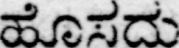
ಹೊಸದು
